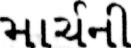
માર્ચની
